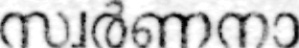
സ്വര്‍ണനാ
